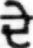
ਦੇ
